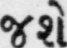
જશે
